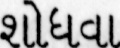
શોધવા
